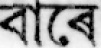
বাৰে
